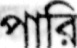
পারি
